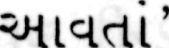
આવતાં'
